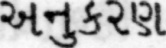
અનુકરણ
